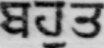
ਬਹੁਤ
